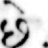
છે.
